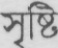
সৃষ্টি
